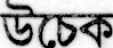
উচেক
